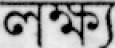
লক্ষ্য
